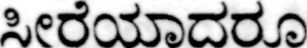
ಸೀರೆಯಾದರೂ
